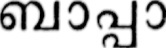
ബാപ്പാ
